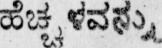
ಹೆಚ್ಚಳವನ್ನು
